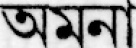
অমনা
